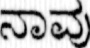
ನಾವು
